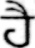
ਹੈ
